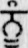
ਨੂੰ
